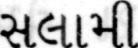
સલામી
